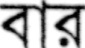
বার
